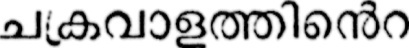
ചക്രവാളത്തിന്റെ
